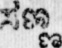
ಸಣ್ಣ
